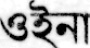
ওইনা
